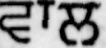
ਵਾਲ
